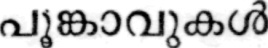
പൂങ്കാവുകള്‍
